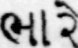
ભારે
